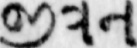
જીવન
